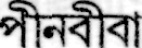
পীনবীবা
